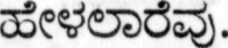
ಹೇಳಲಾರೆವು.
